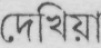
দেখিয়া
